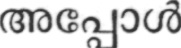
അപ്പോള്‍
